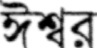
ঈশ্বর
